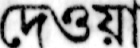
দেওয়া
